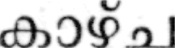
കാഴ്ച
